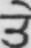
ਤੇ
